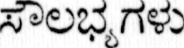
ಸೌಲಭ್ಯಗಳು
